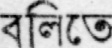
বলিতে
